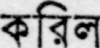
করিল
